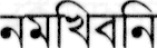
নমখিবনি
